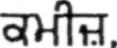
ਕਮੀਜ਼,
